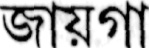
জায়গা
